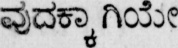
ವುದಕ್ಕಾಗಿಯೇ
